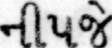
નીપજે
